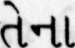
તેના
